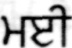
ਮਈ
